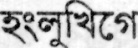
হংলুখিগে
